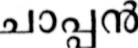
ചാപ്പന്‍
